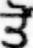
ਤੋਂ
